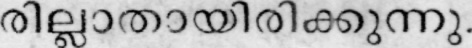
രില്ലാതായിരിക്കുന്നു.
